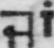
ਜਾਂ
